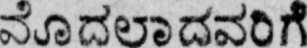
ಮೊದಲಾದವರಿಗೆ
